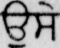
ਉਸੇ
